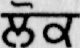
ਲੋਕ
